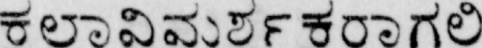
ಕಲಾವಿಮರ್ಶಕರಾಗಲಿ
